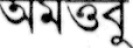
অমত্তুবু
